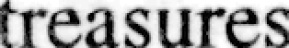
treassures
